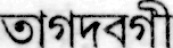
তাগদবগী
